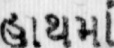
હાથમાં
